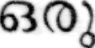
ഒരു
